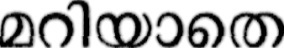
മറിയാതെ
